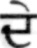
ਦੇ
